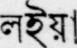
লইয়া
